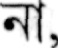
না,
